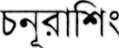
চনূরাশিং
